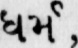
ધર્મ,
